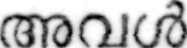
അവള്‍
